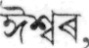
ঈশ্বৰ,
